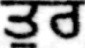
ਤੁਰ
